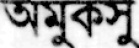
অমুকসু
